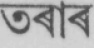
তৰাৰ
